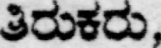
ತಿರುಕರು,
